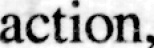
action,
